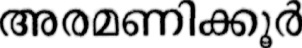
അരമണിക്കൂര്‍
